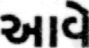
આવે
